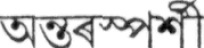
অন্তৰস্পৰ্শী
